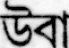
উবা
